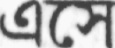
এসে
